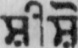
ਸ਼ੀਸ਼ੋ
